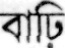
বাঢ়ি
